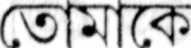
তোমাকে
